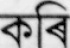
কৰি
